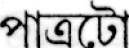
পাত্রটো
